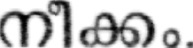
നീക്കം.
